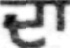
ਦਾ
